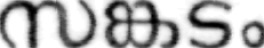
സങ്കടം
